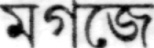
মগজে
